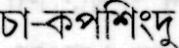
চা-কপশিংদু
